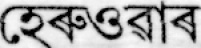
হেৰুওৱাৰ
